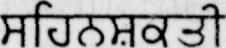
ਸਹਿਨਸ਼ਕਤੀ
